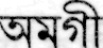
অমগী
